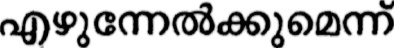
എഴുന്നേല്‍ക്കുമെന്ന്
